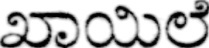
ಖಾಯಿಲೆ
